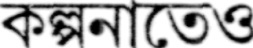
কল্পনাতেও
